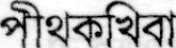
পীথকখিবা
